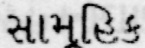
સામૂહિક
